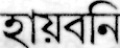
হায়বনি
